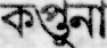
কপ্তুনা
